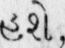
હશે,
